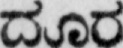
ದೂರ
